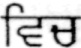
ਵਿਚ
